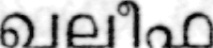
ഖലീഫ
